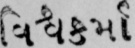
વિશ્વકર્મા
